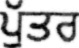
ਪੁੱਤਰ
